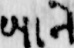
બાને
